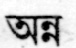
অন্ন
